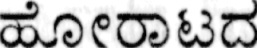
ಹೋರಾಟದ
